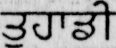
ਤੁਹਾਡੀ
